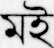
মই
